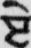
ਏ
